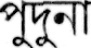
পুদুনা
